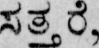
ಸತ್ತರೆ,
